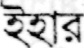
ইহার
